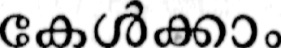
കേള്‍ക്കാം
